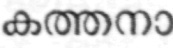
കത്തനാ
